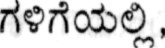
ಗಳಿಗೆಯಲ್ಲಿ,
